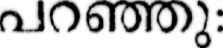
പറഞ്ഞു:
